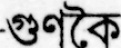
গুণকৈ
